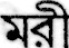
মরী
